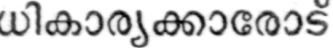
ധികാര്യക്കാരോട്
